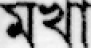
মখা
